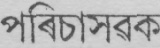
পৰিচাসৱক
